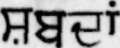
ਸ਼ਬਦਾਂ
